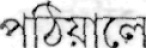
পঠিয়ালে
